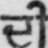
ਦੀ
